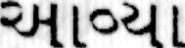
આવ્યા
